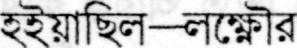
হইয়াছিল—লক্ষ্ণৌর
